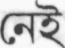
নেই
